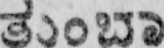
ತುಂಬಾ
